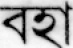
বহা
